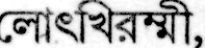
লোৎখিরম্মী,
